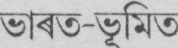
ভাৰত-ভূমিত
